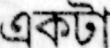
একটা
